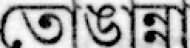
তোঙান্না
